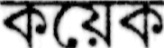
কয়েক
